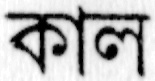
কাল
